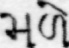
મળે
